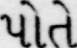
પોતે
